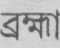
ব্ৰহ্মা
